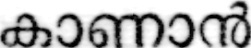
കാണാന്‍
